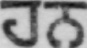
ਹਨ
